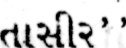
તાસીર"
